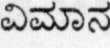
ವಿಮಾನ
